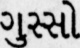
ગુસ્સો
